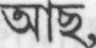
আছ,
